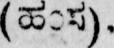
(ಹಂಸ),
